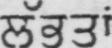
ਲੱਭਤਾਂ
